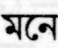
মনে
